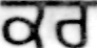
ਕਰ
